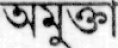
অমুক্তা
